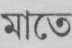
মাতে
